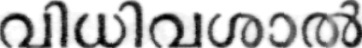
വിധിവശാല്‍
